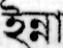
ইন্না
